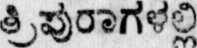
ತ್ರಿಪುರಾಗಳಲ್ಲಿ
